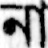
না
